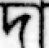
দা
